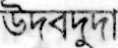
উদবদুদা
